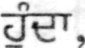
ਹੁੰਦਾ,
